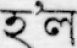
হ'ল
